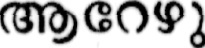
ആറേഴു
